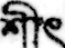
শীৎ
